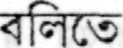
বলিতে
